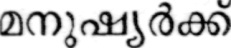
മനുഷ്യര്‍ക്ക്
